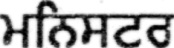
ਮਨਿਸਟਰ
